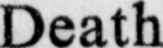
Death
